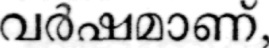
വര്‍ഷമാണ്,
